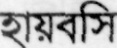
হায়বসি
